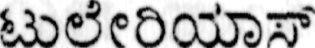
ಟುಲೇರಿಯಾಸ್
